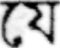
যে
